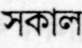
সকাল
